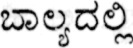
ಬಾಲ್ಯದಲ್ಲಿ
